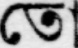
তো
